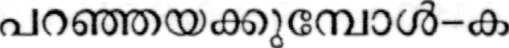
പറഞ്ഞയക്കുമ്പോള്‍-ക
